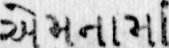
એમનામાં
